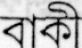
বাকী
